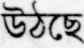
উঠছে
